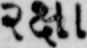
રક્ષા
